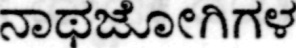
ನಾಥಜೋಗಿಗಳ
